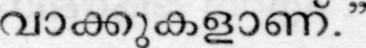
വാക്കുകളാണ്.”
